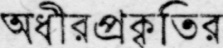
অধীরপ্রকৃতির
